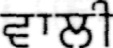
ਵਾਲੀ
